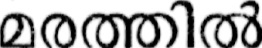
മരത്തില്‍
